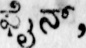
ಫೈನ್,
